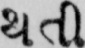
થતી
